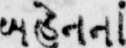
બહેનનાં
